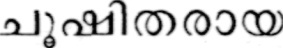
ചൂഷിതരായ
